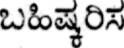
ಬಹಿಷ್ಕರಿಸ
